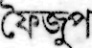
ফৈজুপ
